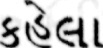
કહેલા
